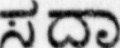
ಸದಾ
